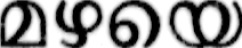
മഴയെ
